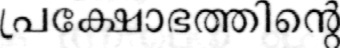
പ്രക്ഷോഭത്തിന്റെ
